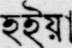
হইয়া
